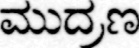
ಮುದ್ರಣ
